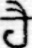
ਹੈ
